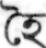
হৈ
